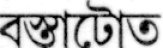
বস্তাটোত
